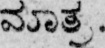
ಮಾತ್ರ.
